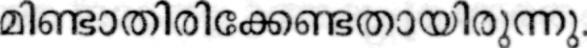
മിണ്ടാതിരിക്കേണ്ടതായിരുന്നു.
